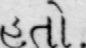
હતો.
